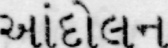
આંદોલન
